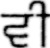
ਵੀ
